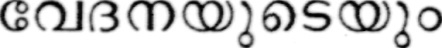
വേദനയുടെയും
